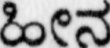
ಹೀನ
